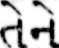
તેને
